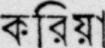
করিয়া
